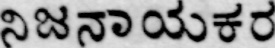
ನಿಜನಾಯಕರ
